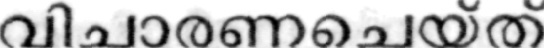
വിചാരണചെയ്ത്
